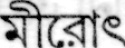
মীরোৎ
